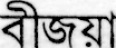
বীজয়া
